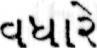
વધારે
